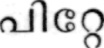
പിറ്റേ
